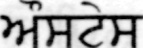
ਔਸਟੇਸ
